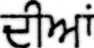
ਦੀਆਂ
